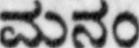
ಮನಂ
